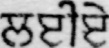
ਲਈਏ
